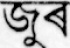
জুৰ
